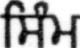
ਸਿੰਮ
